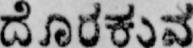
ದೊರಕುವ
